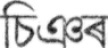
চিঞৰ
